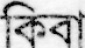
কিবা
